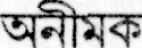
অনীমক
